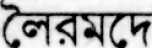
লৈরমদে
